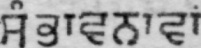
ਸੰਭਾਵਨਾਵਾਂ
